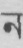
ন
